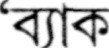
‘ব্যাক
